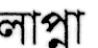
লাপ্না
